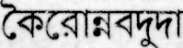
কৈরোন্নবদুদা
